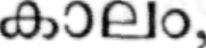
കാലം,
